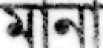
মানা
